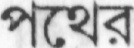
পথের
